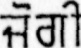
ਜੋਗੀ
